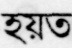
হয়ত
